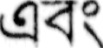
এবং
